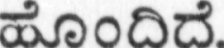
ಹೊಂದಿದೆ.
